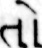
તો
